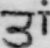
ਤਾਂ
